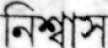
নিশ্বাস
